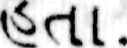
હતા.
